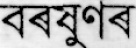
বৰষুণৰ
